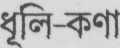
ধূলি-কণা
